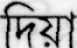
দিয়া
